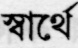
স্বার্থে
